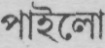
পাইলো
